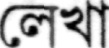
লেখা
